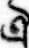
ঐ
